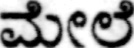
ಮೇಲೆ
